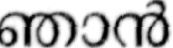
ഞാന്‍
